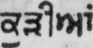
ਕੁੜੀਆਂ
